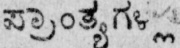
ಪ್ರಾಂತ್ಯಗಳಲ್ಲ
